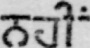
ਨਹੀਂ
